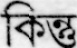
কিন্তু
